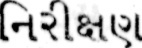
નિરીક્ષણ
